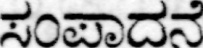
ಸಂಪಾದನೆ
